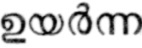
ഉയര്‍ന്ന
